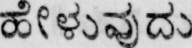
ಹೇಳುವುದು
